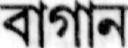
বাগান
